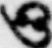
ও
